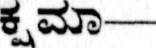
ಕ್ಷಮಾ-
